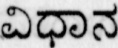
ವಿಧಾನ
